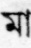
মা
